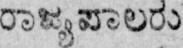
ರಾಜ್ಯಪಾಲರು
